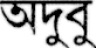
অদুবু
